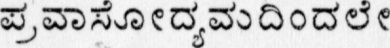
ಪ್ರವಾಸೋದ್ಯಮದಿಂದಲೇ
